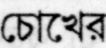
চোখের
